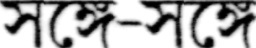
সঙ্গে-সঙ্গে
